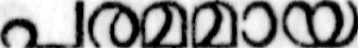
പരമമായ
